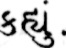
કહ્યું.
